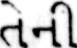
તેની
